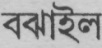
বঝাইল
